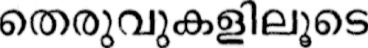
തെരുവുകളിലൂടെ
